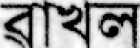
ৱাখল
